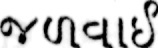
જળવાઈ
